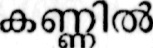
കണ്ണില്‍
